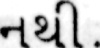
નથી.
